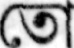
তো
